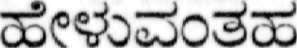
ಹೇಳುವಂತಹ
